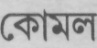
কোমল
